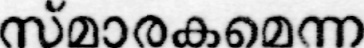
സ്മാരകമെന്ന
